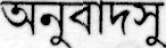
অনুবাদসু
